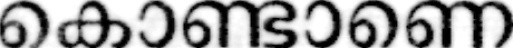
കൊണ്ടാണെ
